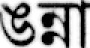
ঙন্না
